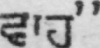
ਵਾਹ''
